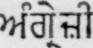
ਅੰਗ੍ਰੇਜ਼ੀ
